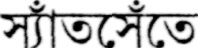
স্যাঁতসেঁতে
